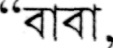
“বাবা,
